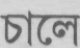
চালে
